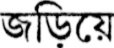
জড়িয়ে
